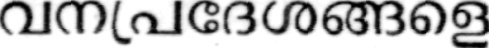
വനപ്രദേശങ്ങളെ
